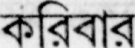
করিবার
